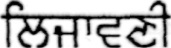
ਲਿਜਾਵਣੀ
